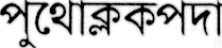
পুথোক্লকপদা
